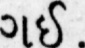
ગઈ.
